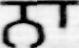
ਨਾ
